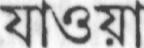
যাওয়া
